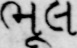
ભૂલ
